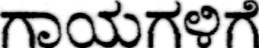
ಗಾಯಗಳಿಗೆ
